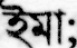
ইমা;
